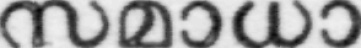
സമാധാ
